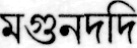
মগুনদদি
